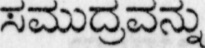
ಸಮುದ್ರವನ್ನು
